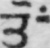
ਤੋਂ
